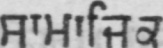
ਸਾਮਾਜਿਕ
